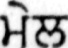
ਮੇਲ
